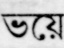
ভয়ে
